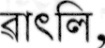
ৱাৎলি,
